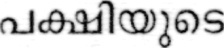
പക്ഷിയുടെ
